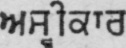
ਅਸ੍ਵੀਕਾਰ
